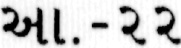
.આ.-૨૨
